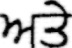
ਅਤੇ
